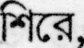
শিরে,
